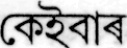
কেইবাৰ
